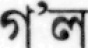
গ'ল
